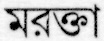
মরক্তা
